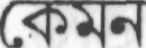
কেমন
